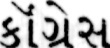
કૉંગ્રેસ
